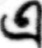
এ
